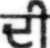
ਦੀ
